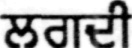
ਲਗਦੀ
